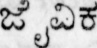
ಜೈವಿಕ
